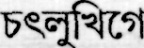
চৎলুখিগে
